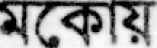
মকোয়
